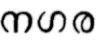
നഗര
